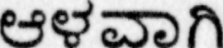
ಆಳವಾಗಿ
